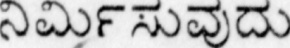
ನಿರ್ಮಿಸುವುದು
